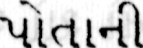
પોતાની
